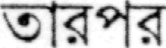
তারপর
